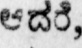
ಆದರೆ,
